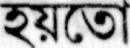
হয়তো
